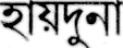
হায়দুনা
